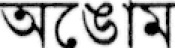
অঙোম
